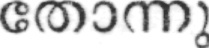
തോന്നു
